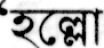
‘হল্লো
